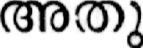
അതു
